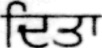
ਦਿਤਾ
